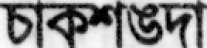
চাকশঙদা
